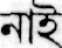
নাই
